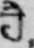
ਹੈ,
